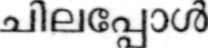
ചിലപ്പോള്‍
